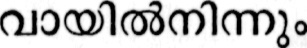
വായില്‍നിന്നും
